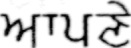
ਆਪਣੇ
